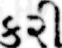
કરી
